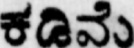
ಕಡಿಮೆ
